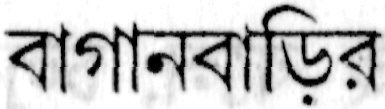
বাগানবাড়ির
